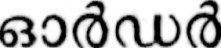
ഓര്‍ഡര്‍
